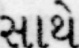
સાથે
